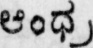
ಆಂಧ್ರ
